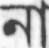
না
